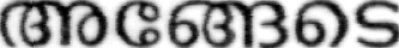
അങ്ങേടെ
